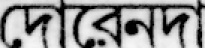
দোরেনদা
